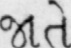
જાતે
